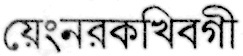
য়েংনরকখিবগী
